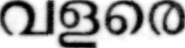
വളരെ
